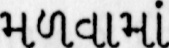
મળવામાં
